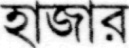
হাজার
